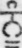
ਨੂੰ
